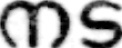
നട
